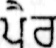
ਪੈਰ
